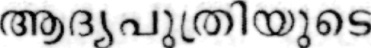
ആദ്യപുത്രിയുടെ
